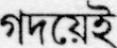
গদয়েই
